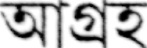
আগ্রহ
